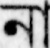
না
